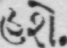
હશે
